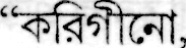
“করিগীনো,
